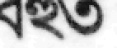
বহুত
